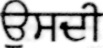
ਉਸਦੀ
